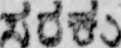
ಸರಕು
